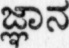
ಜ್ಞಾನ
